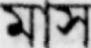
মাস
